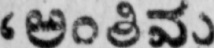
‘ಅಂತಿಮ
